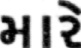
મારે
